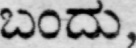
ಬಂದು,
